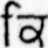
ਕਿ
